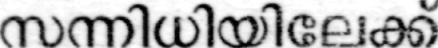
സന്നിധിയിലേക്ക്
